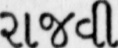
રાજવી
